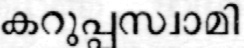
കറുപ്പസ്വാമി
